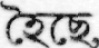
হৈছে,
